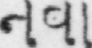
નવા
